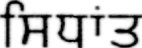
ਸਿਧਾਂਤ
